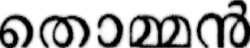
തൊമ്മന്‍
